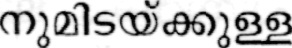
നുമിടയ്ക്കുള്ള
